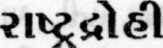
રાષ્ટ્રદ્રોહી
